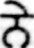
ਨੇ
